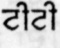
ਟੀਟੀ
